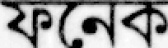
ফনেক
